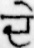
ਦੇ
